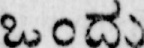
ಒಂದು
